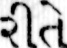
રીતે
